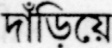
দাঁড়িয়ে
